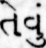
તેવું
